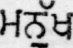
ਮਨੁੱਖ
